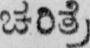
ಚರಿತ್ರೆ
